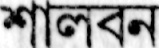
শালবন
